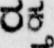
ರಕ್ತ
